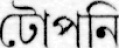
টোপনি
